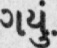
ગયું.
